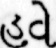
હવે
